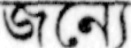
জন্যে
